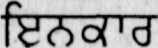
ਇਨਕਾਰ
